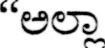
"ಅಲ್ಲಾ
